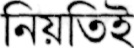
নিয়তিই
